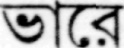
ভারে
